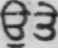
ਉਤੇ
